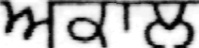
ਅਕਾਲ
